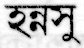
হন্নসু
